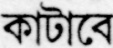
কাটাবে
